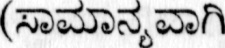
(ಸಾಮಾನ್ಯವಾಗಿ
